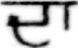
ਦਾ
